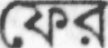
ফের
